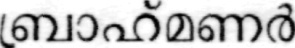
ബ്രാഹ്മണര്‍
